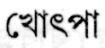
খোৎপা
